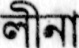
লীনা
